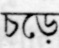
চড়ে
